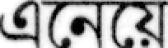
এনেয়ে
